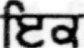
ਇਕ
